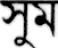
সুম
